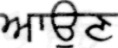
ਆਉਣ
